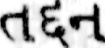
તદ્દન
